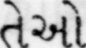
તેઓ
